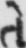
તે
